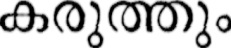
കരുത്തും
